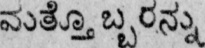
ಮತ್ತೊಬ್ಬರನ್ನು
